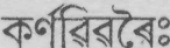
কৰ্ণৱিৱৰৈঃ
